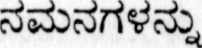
ನಮನಗಳನ್ನು
